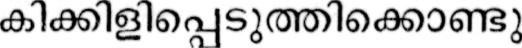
കിക്കിളിപ്പെടുത്തിക്കൊണ്ടു
